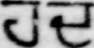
ਹਦ
